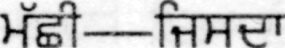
ਮੱਛੀ-ਜਿਸਦਾ
